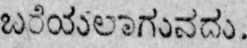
ಬರೆಯಲಾಗುವದು.,
